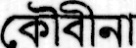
কৌবীনা
